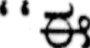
"ಈ
